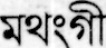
মথংগী
